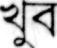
খুব
